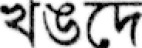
খঙদে
